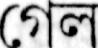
গেল
